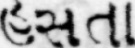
હસતા
